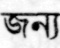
জন্য
